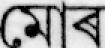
মোৰ
